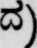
ದ)
